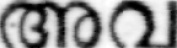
അവ
